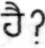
ਹੈ?
